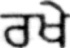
ਰਖੇ
